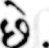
છે.
